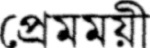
প্রেমময়ী
